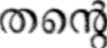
തന്റെ
